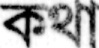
কথা
